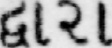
દ્વારા
